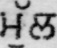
ਮੁੱਲ
